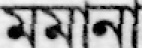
মমানা
